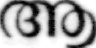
ആ
